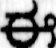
ಈ
